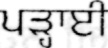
ਪੜ੍ਹਾਈ
